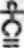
ਨੂੰ
